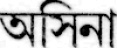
অসিনা
